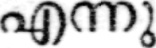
എന്നു
